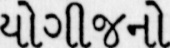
યોગીજનો
